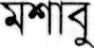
মশাবু
